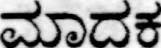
ಮಾದಕ
